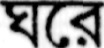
ঘরে
